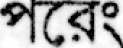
পরেং
